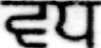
ਵਧ
